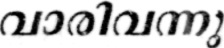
വാരിവന്നു
